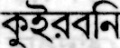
কুইরবনি
